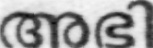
അഭി
